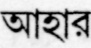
আহার
